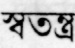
স্বতন্ত্র
